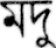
মদু
